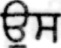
ਉਸ
